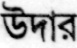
উদার
